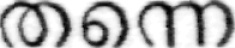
തന്നെ
